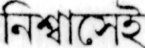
নিশ্বাসেই
